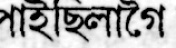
পাইছিলাগৈ
